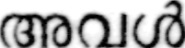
അവള്‍
